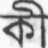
কী
